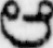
ಆ
